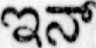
ಇನ್
